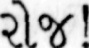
રોજ!
